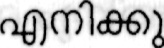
എനിക്കു
